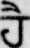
ਹੈ
